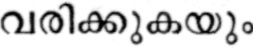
വരിക്കുകയും
